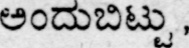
ಅಂದುಬಿಟ್ಟು,
